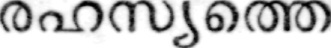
രഹസ്യത്തെ
